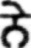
ਨੇ
